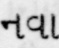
નવા
